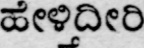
ಹೇಳ್ತಿದೀರಿ
